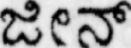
ಜೀನ್
